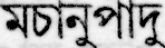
মচানুপাদু
